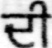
ਦੀ
